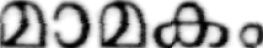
മാമകം
